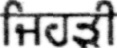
ਜਿਹੜੀ
